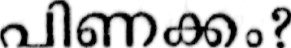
പിണക്കം?
